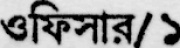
ওফিসার/১
